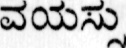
ವಯಸ್ಸು
